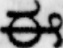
ಈ
